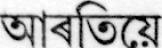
আৰতিয়ে
